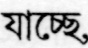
যাচ্ছে,
